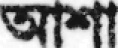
আশা
